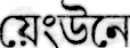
য়েংউনে
